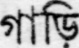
গাড়ি
